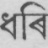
ধৰি
